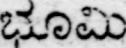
ಭೂಮಿ
